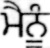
ਮੈਨੂੰ
